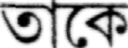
তাকে
